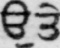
ਉਤੇ
